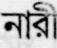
নারী
